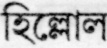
হিল্লোল
